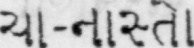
ચા-નાસ્તો
